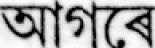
আগৰে
